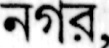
নগর,
